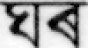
ঘৰ
